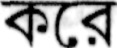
করে
